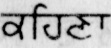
ਕਹਿਣਾ
